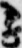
કે
